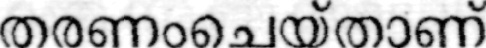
തരണംചെയ്താണ്
